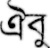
ঐবু
